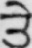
ਤੇ
